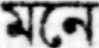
মনে
